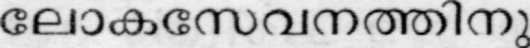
ലോകസേവനത്തിനു
